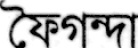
ফৈগন্দা
